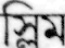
স্লিম
